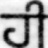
ਹੀ
